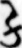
કે
